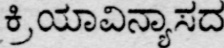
ಕ್ರಿಯಾವಿನ್ಯಾಸದ
